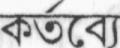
কর্তব্যে
